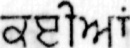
ਕਈਆਂ
